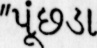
"પૂંછડા
